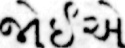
જોઈએ
